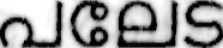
പലേട
